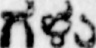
ಗಳು
